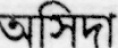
অসিদা
